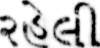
રહેલી
